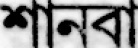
শানবা
